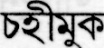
চহীমুক
